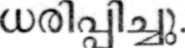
ധരിപ്പിച്ചു.
